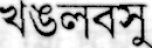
খঙলবসু
